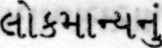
લોકમાન્યનું
